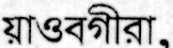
য়াওবগীরা,
